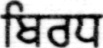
ਬਿਰਧ
